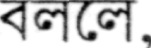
বললে,
